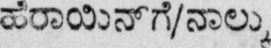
ಹೆರಾಯಿನ್‌ಗೆ/ನಾಲ್ಕು
